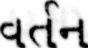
વર્તન
